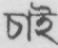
চাই
